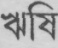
ঋষি
